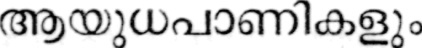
ആയുധപാണികളും
